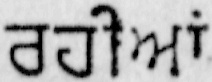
ਰਹੀਆਂ
